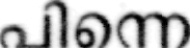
പിന്നെ
